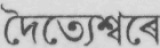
দৈত্যেশ্বৰে
